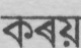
কৰয়
